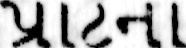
પ્રાટના
